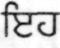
ਇਹ
